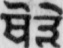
ਥੋੜੇ
